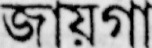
জায়গা
